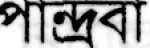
পান্দ্রবা
